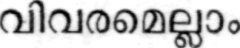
വിവരമെല്ലാം
